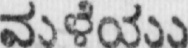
ಮಳೆಯು
